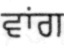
ਵਾਂਗ
